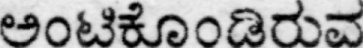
ಅಂಟಿಕೊಂಡಿರುವ
